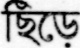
ছিঁড়ে
